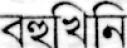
বহুখিনি
